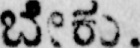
ಬೇಕು.
